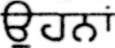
ਉਹਨਾਂ
